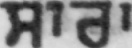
ਸਾਰਾ
